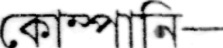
কোম্পানি–
